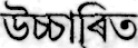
উচ্চাৰিত
